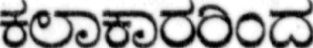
ಕಲಾಕಾರರಿಂದ
